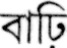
বাঢ়ি
